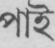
পাই
